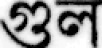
গুল
